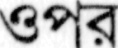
ওপর
